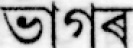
ভাগৰ
